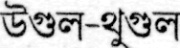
উগুল-থুগুল
